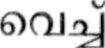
വെച്ച്
